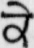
ਕੇ
